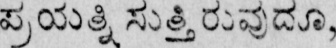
ಪ್ರಯತ್ನಿಸುತ್ತಿರುವುದೂ,
